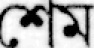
শেম
